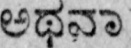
ಅಥವಾ
